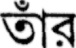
তাঁর
